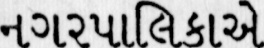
નગરપાલિકાએ
